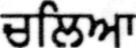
ਚਲਿਆ
